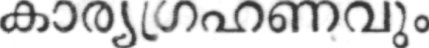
കാര്യഗ്രഹണവും
